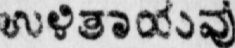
ಉಳಿತಾಯವು
